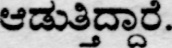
ಆಡುತ್ತಿದ್ದಾರೆ.
